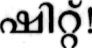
ഷിറ്റ്!
